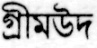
গ্রীমউদ
